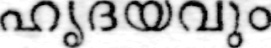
ഹൃദയവും
